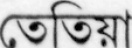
তেতিয়া
